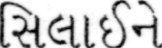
સિલાઈને
